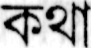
কথা
